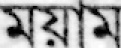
ময়াম
